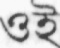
ওই
